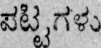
ಪಟ್ಟಿಗಳು
